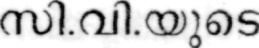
സി.വി.യുടെ
